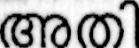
അതി
